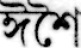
ঈশৈ
